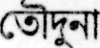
তৌদুনা
